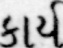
કાર્ય
